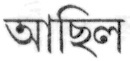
আছিল
